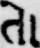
તો
